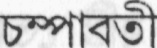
চম্পাবতী
